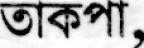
তাকপা,
